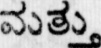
ಮತ್ತು
